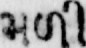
મળી
